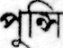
পুন্সি
